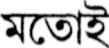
মতোই
